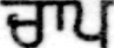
ਚਾਪ
